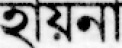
হায়না
